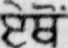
ਏਥੋਂ
